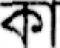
কা
